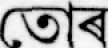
তোৰ
